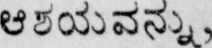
ಆಶಯವನ್ನು,
